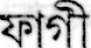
ফাগী
